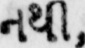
નથી,
